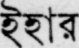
ইহার
